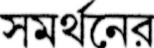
সমর্থনের
